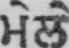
ਮੇਲੇ
